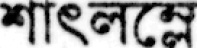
শাৎলম্লে
